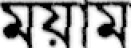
ময়াম
